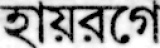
হায়রগে
